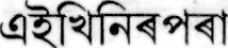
এইখিনিৰপৰা
